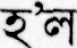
হ'ল
